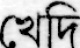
খেদি
